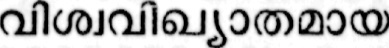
വിശ്വവിഖ്യാതമായ
